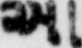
આ
